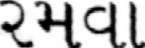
રમવા
